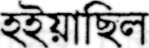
হইয়াছিল
